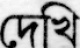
দেখি
